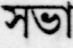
সভা
